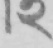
।হ
